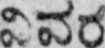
ವಿವರ
